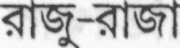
রাজু-রাজা
